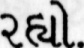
રહ્યો.
